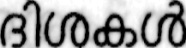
ദിശകള്‍
